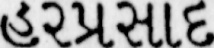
હરપ્રસાદ
